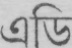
এড়ি
